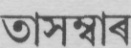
তাসম্বাৰ
